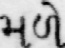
મળે
